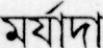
মর্যাদা
